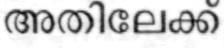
അതിലേക്ക്
